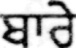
ਬਾਰੇ
